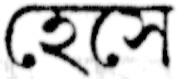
হেসে
